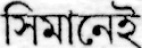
সিমানেই
